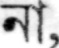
না,
